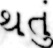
થતું
